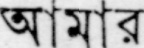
আমার
